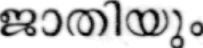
ജാതിയും
